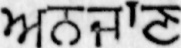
ਅਨਜਾਣ
